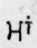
ਮਾਂ
